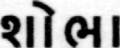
શોભા
